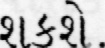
શકશે.
